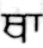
ਥਾ
